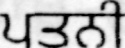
ਪਤਨੀ
